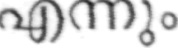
എന്നും
